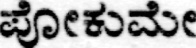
ಪೋಕುಮೇ
